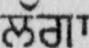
ਲੱਗਾ
